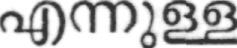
എന്നുള്ള
